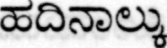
ಹದಿನಾಲ್ಕು
